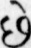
છે
